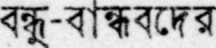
বন্ধু-বান্ধবদের
